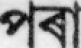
পৰা
